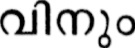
വിനും
